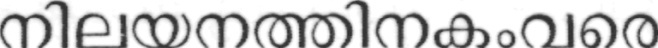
നിലയനത്തിനകംവരെ
